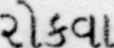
રોકવા
